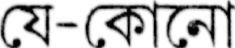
যে-কোনো
